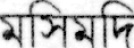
মসিমদি
